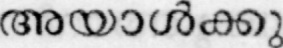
അയാള്‍ക്കു
